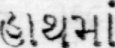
હાથમાં
